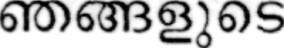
ഞങ്ങളുടെ
